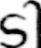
ടി
